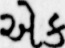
એક
